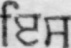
ਇਸ
